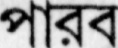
পারব
